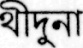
থীদুনা
